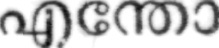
എന്തോ
